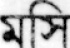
মসি
